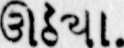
ઊઠ્યા.
